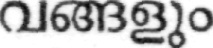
വങ്ങളും
